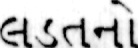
લડતનો
